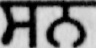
ਸਨ
